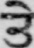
ਤੇ
